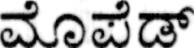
ಮೊಪೆಡ್
